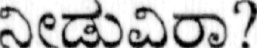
ನೀಡುವಿರಾ?
